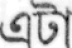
এটা
